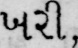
ખરી,
